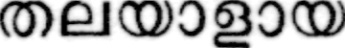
തലയാളായ
